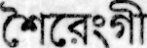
শৈরেংগী
